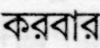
করবার
